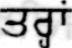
ਤਰ੍ਹਾਂ
